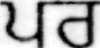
ਪਰ
